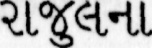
રાજુલના
